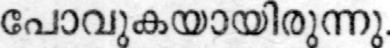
പോവുകയായിരുന്നു.
